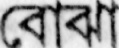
বোঝা
